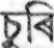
চুৰি
